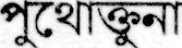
পুথোক্তুনা
